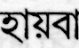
হায়বা
